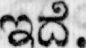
ಇದೆ.
